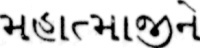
મહાત્માજીને
